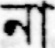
না
